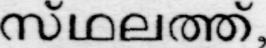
സ്ഥലത്ത്,
